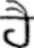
ਹੈ
